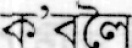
ক'বলৈ
